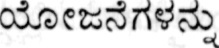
ಯೋಜನೆಗಳನ್ನು
